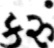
કરું
